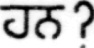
ਹਨ?
